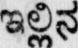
ಇಲ್ಲಿನ
